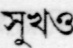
সুখও
